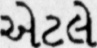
એટલે
